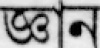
জ্ঞান
